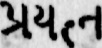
પ્રયત્ન
